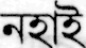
নহাই
